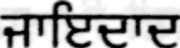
ਜਾਇਦਾਦ
